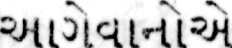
આગેવાનોએ
